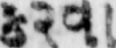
કરવા
